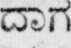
ದಾಗ
